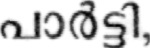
പാര്‍ട്ടി,
